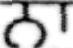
ਨਾ
